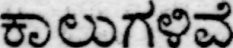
ಕಾಲುಗಳಿವೆ
